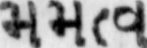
મમત્વ
